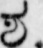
ಶ.
